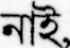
নাই,
